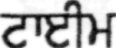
ਟਾਈਮ
